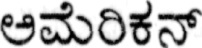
ಅಮೆರಿಕನ್
